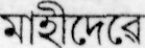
মাহীদেৱে
